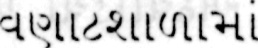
વણાટશાળામાં
